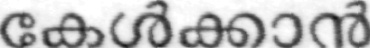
കേള്‍ക്കാന്‍
